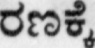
ರಣಕ್ಕೆ
